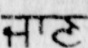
ਜਾਣ
